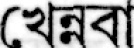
খেন্নবা
